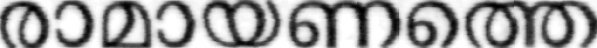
രാമായണത്തെ
